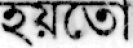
হয়তো
